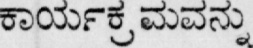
ಕಾರ್ಯಕ್ರಮವನ್ನು
